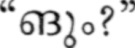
"ങും?"
